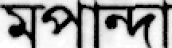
মপান্দা
